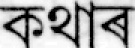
কথাৰ
